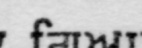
ਗਿਆ
